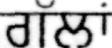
ਗੱਲਾਂ
